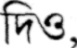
দিও,
